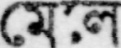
মেলে
